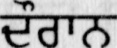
ਦੌਰਾਨ
